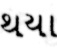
થયા
